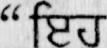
''ਇਹ
